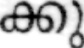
ക്കു
